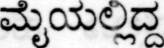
ಮೈಯಲ್ಲಿದ್ದ
